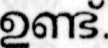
ഉണ്ട്.
